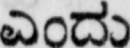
ಎಂದು
